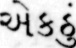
એકઠું
